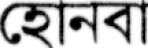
হোনবা
